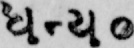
ધન્ય.
